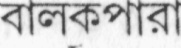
বালকপারা
